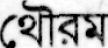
থৌরম
